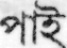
পাই
